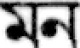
মন
